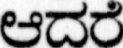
ಆದರೆ
